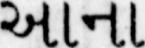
આના
